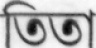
তিতা
